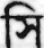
সি
